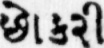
છોકરી
